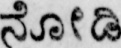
ನೋಡಿ
